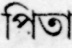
পিতা
